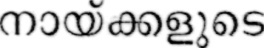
നായ്ക്കളുടെ
